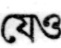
যেও
